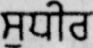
ਸੁਧੀਰ
